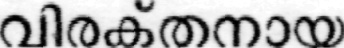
വിരക്തനായ
